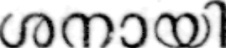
ശനായി
